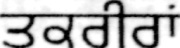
ਤਕਰੀਰਾਂ
